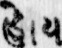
હોય
